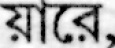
য়ারে,
